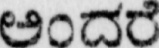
ಅಂದರೆ
